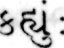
કહ્યુંઃ
